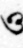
ও
